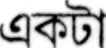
একটা
